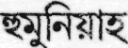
হুমুনিয়াহ
